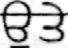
ਉਤੇ
